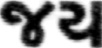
જય
